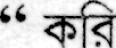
“করি
